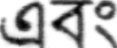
এবং
